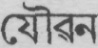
যৌৱন
